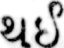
થઈ
